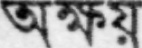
অক্ষয়
